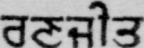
ਰਣਜੀਤ
